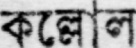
কল্লোল
